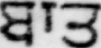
ਬਾਤ
